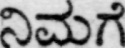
ನಿಮಗೆ
